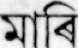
মাৰি
